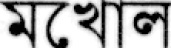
মখোল
